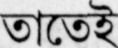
তাতেই
